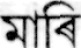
মাৰি
